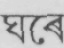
ঘৰে
